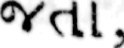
જતા,
